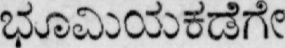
ಭೂಮಿಯಕಡೆಗೇ
